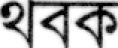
থবক
